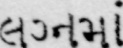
લગ્નમાં
